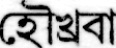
হৌখ্রবা
